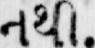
નથી.
